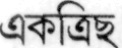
একত্রিছ
